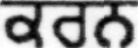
ਕਰਨ
